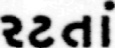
રટતાં
